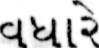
વધારે
